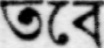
তবে
